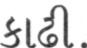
કાઢી.
